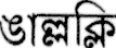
ঙাল্লক্লি
